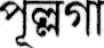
পূল্লগা
